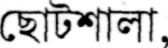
ছোটশালা,
